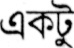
একটু
